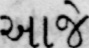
આજે
